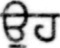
ਉਹ
